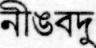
নীঙবদু
